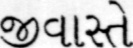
જીવાસ્તે
